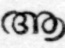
ആ
